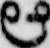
ಆ
